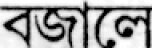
বজালে
